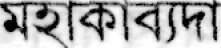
মহাকাব্যদা
